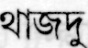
থাজদু
